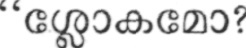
ശ്ലോകമോ?
